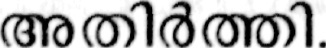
അതിര്‍ത്തി.
